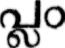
പ്ളം
